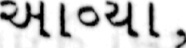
આવ્યા,
